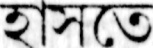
হাসতে
